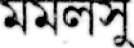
মমলসু
